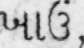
ખાઉં,
